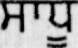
ਸਾਧੂ
